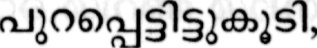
പുറപ്പെട്ടിട്ടുകൂടി,
